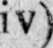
iv)
